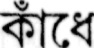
কাঁধে
